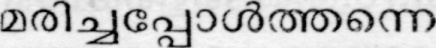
മരിച്ചപ്പോള്‍ത്തന്നെ
